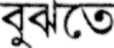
বুঝতে
